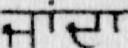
ਜਾਂਦਾ
